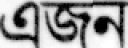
এজন
